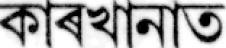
কাৰখানাত
